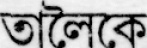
তালৈকে
